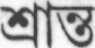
শ্রান্ত
